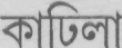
কাঢ়িলা
